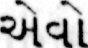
એવો
